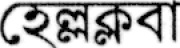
হেল্লক্লবা
